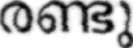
രണ്ടു
